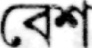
বেশ
